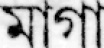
মাগা
